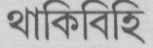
থাকিবিহি
